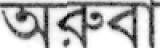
অরুবা
